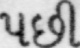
પછી
